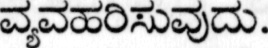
ವ್ಯವಹರಿಸುವುದು.
